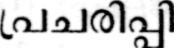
പ്രചരിപ്പി
